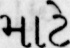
માટે
